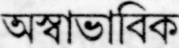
অস্বাভাবিক
